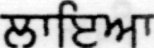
ਲਾਇਆ
